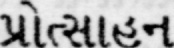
પ્રોત્સાહન
